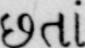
છતાં
